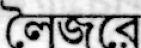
লৈজরে
